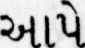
આપે
